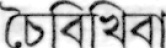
চৈবিখিবা
